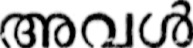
അവള്‍
